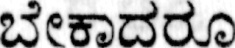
ಬೇಕಾದರೂ
